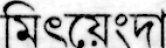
মিৎয়েংদা
